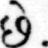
છે.
